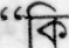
"কি
